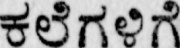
ಕಲೆಗಳಿಗೆ
